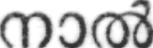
നാല്‍
